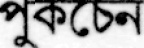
পুকচেল
